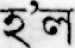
হ'ল
